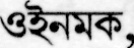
ওইনমক,
